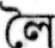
লৈ
